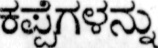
ಕಪ್ಪೆಗಳನ್ನು
